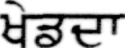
ਖੇਡਦਾ
